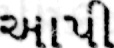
આપી
